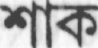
শাক
